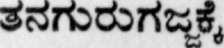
ತನಗುರುಗಜ್ಜಕ್ಕೆ
